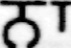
ਨਾ
